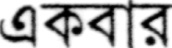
একবার
